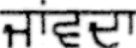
ਜਾਂਵਦਾ
